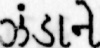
ઝંડાને
